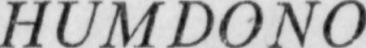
HUMDONO
